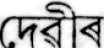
দেৱীৰ
